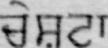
ਚੇਸ਼ਟਾ
